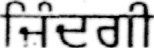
ਜ਼ਿੰਦਗੀ
